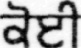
ਕੋਈ
